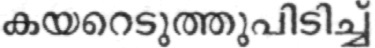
കയറെടുത്തുപിടിച്ച്
